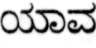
ಯಾವ
